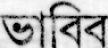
ভাবিব
